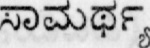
ಸಾಮರ್ಥ್ಯ
